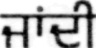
ਜਾਂਦੀ
